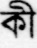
কী
